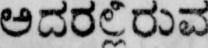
ಅದರಲ್ಲಿರುವ
